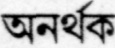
অনর্থক
